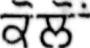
ਕੋਲੋਂ
